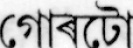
গোৰটো
